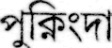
পুক্নিংদা
